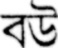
বউ
